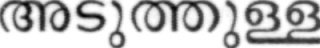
അടുത്തുള്ള
